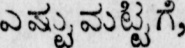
ಎಷ್ಟುಮಟ್ಟಿಗೆ,
